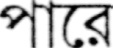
পারে
